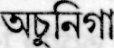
অচুনিগা
